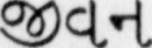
જીવન
